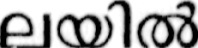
ലയില്‍
